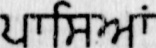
ਪਾਸਿਆਂ
